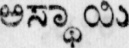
ಅಸ್ಥಾಯಿ
